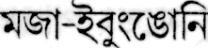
মজা-ইবুংঙোনি
